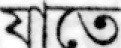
যাতে
